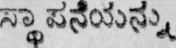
ಸ್ಥಾಪನೆಯನ್ನು
